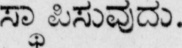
ಸ್ಥಾಪಿಸುವುದು.
